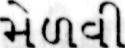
મેળવી
